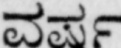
ವರ್ಷ
